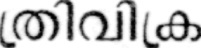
ത്രിവിക്ര
